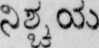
ನಿಶ್ಚಯ
